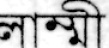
লান্মী
